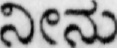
ನೀನು
